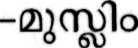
-മുസ്ളിം
